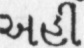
અહીં
